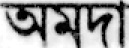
অমদা
